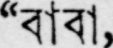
‘‘বাবা,
